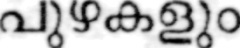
പുഴകളും
